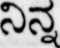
ನಿನ್ನ
